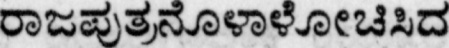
ರಾಜಪುತ್ರನೊಳಾಳೋಚಿಸಿದ
